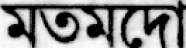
মতমদো
